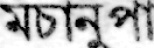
মচানুপা
